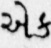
એક
